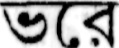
ভরে
